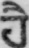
ਹੈ
